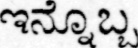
ಇನ್ನೊಬ್ಬ
